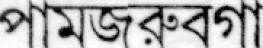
পামজরুবগী
